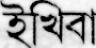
ইখিবা
